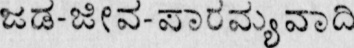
ಜಡ-ಜೀವ-ಪಾರಮ್ಯವಾದಿ
